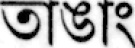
তাঙাং
